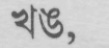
খঙ,
